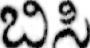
ಬಿಸಿ
